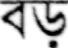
বড়
